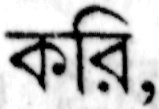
করি,
